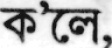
ক'লে,
